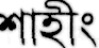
শাহীং
